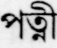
পত্নী
